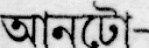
আনটো-
